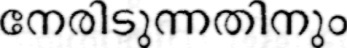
നേരിടുന്നതിനും
